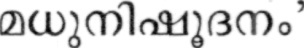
മധുനിഷൂദനം'
